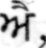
ਐ,
